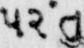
પરંતુ
